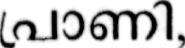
പ്രാണി,
